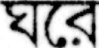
ঘরে
